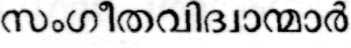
സംഗീതവിദ്വാന്മാര്‍
